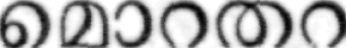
മൊറതറ
